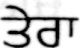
ਤੇਰਾ
